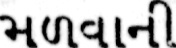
મળવાની
